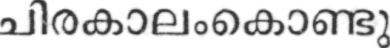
ചിരകാലംകൊണ്ടു
